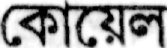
কোয়েল
